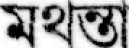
মথন্তা
